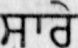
ਸਾਰੇ
